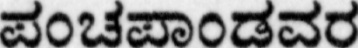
ಪಂಚಪಾಂಡವರ
